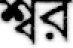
শ্বর
